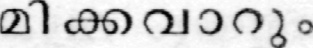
മിക്കവാറും
